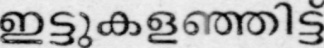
ഇട്ടുകളഞ്ഞിട്ട്
